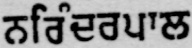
ਨਰਿੰਦਰਪਾਲ
